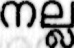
നല്ല
